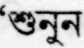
‘শুনুন
